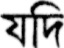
যদি
